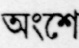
অংশে
